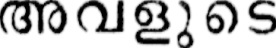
അവളുടെ
